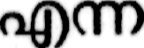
എന്ന
